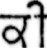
ਕੀ
